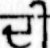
ਦੀ
